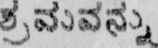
ಶ್ರಮವನ್ನು
